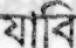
যাবি
